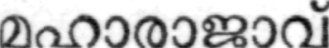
മഹാരാജാവ്
